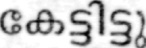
കേട്ടിട്ടു
